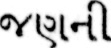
જણની
